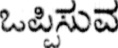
ಒಪ್ಪಿಸುವ
